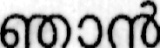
ഞാന്‍
